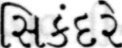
સિકંદરે
